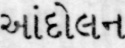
આંદોલન
